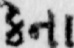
કેના
